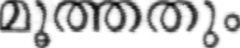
മൂത്തതും
